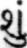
શું
